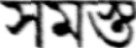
সমস্ত
